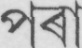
পৰা
